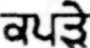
ਕਪੜੇ
